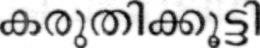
കരുതിക്കൂട്ടി
